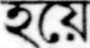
হয়ে
